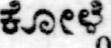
ಕೋಳ್ಗೆ
